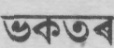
ভকতৰ
